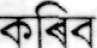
কৰিব
